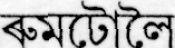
ৰুমটোলৈ
